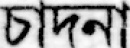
চাদনা
